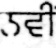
ਨਵੀਂ
